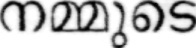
നമ്മുടെ
